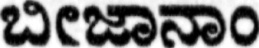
ಬೀಜಾನಾ೦
